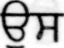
ਉਸ
